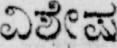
ವಿಶೇಷ
